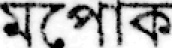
মপোক
